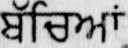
ਬੱਚਿਆਂ
